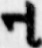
ન
